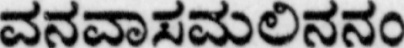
ವನವಾಸಮಲಿನನಂ
